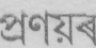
প্ৰণয়ৰ
